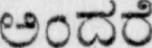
ಅಂದರೆ
